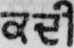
ਕਦੀ
